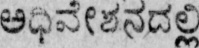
ಅಧಿವೇಶನದಲ್ಲಿ
